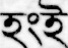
হংই
